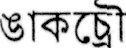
ঙাকচ্রৌ
